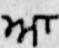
ਆ
